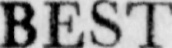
BEST
